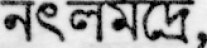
নৎলমদ্রে,
